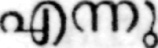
എന്നു
